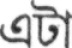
এটা
